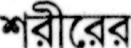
শরীরের
